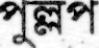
পুল্লপ
